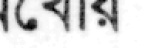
লবোর
